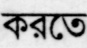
করতে
